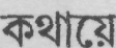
কথায়ে
